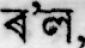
ৰ'ল,
